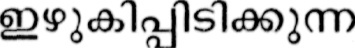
ഇഴുകിപ്പിടിക്കുന്ന
